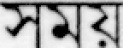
সময়
